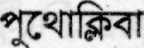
পুথোক্লিবা
